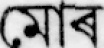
মোৰ
